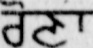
ਰੋਣਾ
